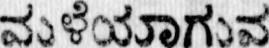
ಮಳೆಯಾಗುವ
